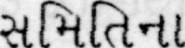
સમિતિના
